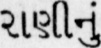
રાણીનું
